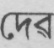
দেৱ
